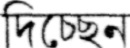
দিচ্ছেন
